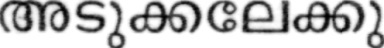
അടുക്കലേക്കു
